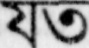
যত
